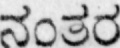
ನಂತರ
